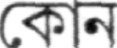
কোন
